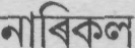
নাৰিকল
